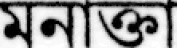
মনাক্তা
